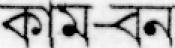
কাম-বন
